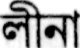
লীনা
